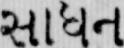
સાધન
